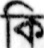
কি
